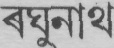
ৰঘুনাথ
